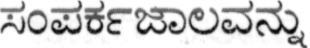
ಸಂಪರ್ಕಜಾಲವನ್ನು
